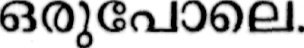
ഒരുപോലെ.
